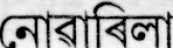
নোৱাৰিলা
